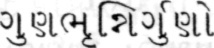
ગુણભૃન્નિર્ગુણો
